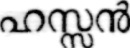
ഹസ്സന്‍
